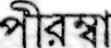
পীরম্বা
